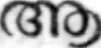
ആ
